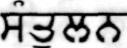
ਸੰਤੁਲਨ
